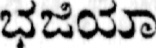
ಭಜಿಯಾ
